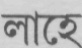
লাহে
